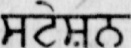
ਸਟੇਸ਼ਨ
